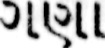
ગણાં
